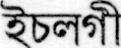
ইচলগী
